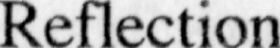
Reflection
